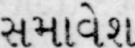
સમાવેશ
